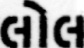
લોલ
